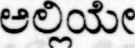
ಅಲ್ಲಿಯೇ
